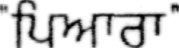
''ਪਿਆਰਾ''
